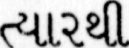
ત્યારથી
